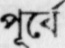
পূর্বে
